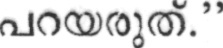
പറയരുത്."
